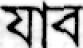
যাব
